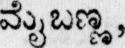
ಮೈಬಣ್ಣ,
